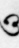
ও
